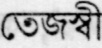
তেজস্বী
